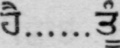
ਹੈ.........ਤੂੰ
